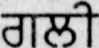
ਗਲੀ
